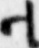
ન
